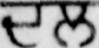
ਦਲ
